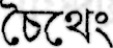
চৈথেং
